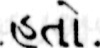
હતો.
